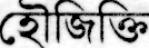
হৌজিক্তি
